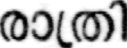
രാത്രി
